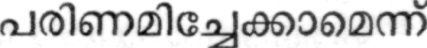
പരിണമിച്ചേക്കാമെന്ന്
